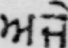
ਅਜੇ
